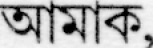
আমাক,
